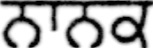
ਨਾਨਕ
